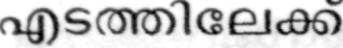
എടത്തിലേക്ക്
